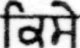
ਕਿਸੇ
